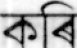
কৰি
